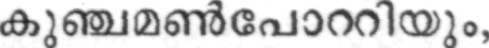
കുഞ്ചമണ്‍പോററിയും,
